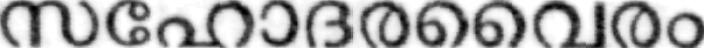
സഹോദരവൈരം
